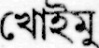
খোইমু
